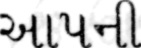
આપની
